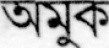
অমুক
